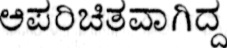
ಅಪರಿಚಿತವಾಗಿದ್ದ
